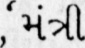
'મંત્રી
